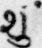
શું
